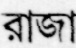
রাজা
